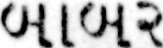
બાબર
